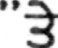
''ਤੇ
